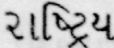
રાષ્ટ્રિય
